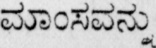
ಮಾಂಸವನ್ನು
